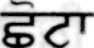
ਛੋਟਾ
